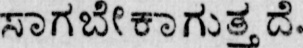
ಸಾಗಬೇಕಾಗುತ್ತದೆ.
